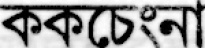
ককচেংনা
